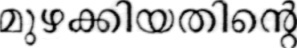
മുഴക്കിയതിന്റെ
